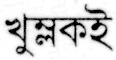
খুম্লকই
